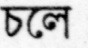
চলে
